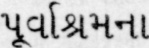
પૂર્વાશ્રમના
